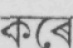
কৰে
